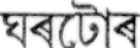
ঘৰটোৰ
